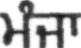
ਮੰਜਾ
